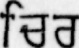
ਚਿਰ
